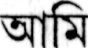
আমি
